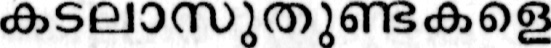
കടലാസുതുണ്ടകളെ
